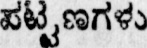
ಪಟ್ಟಣಗಳು
